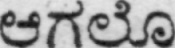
ಆಗಲೊ
